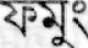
ফমুং
